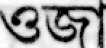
ওজা
